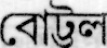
বোট্টল
